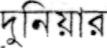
দুনিয়ার
